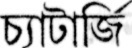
চ্যাটার্জি
